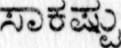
ಸಾಕಷ್ಟು
